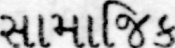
સામાજિક
